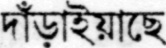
দাঁড়াইয়াছে
